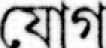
যোগ
